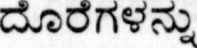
ದೊರೆಗಳನ್ನು
